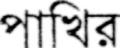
পাখির
